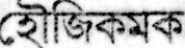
হৌজিকমক
